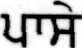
ਪਾਸੇ
